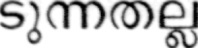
ടുന്നതല്ല
